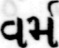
વર્મ
